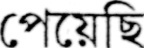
পেয়েছি
